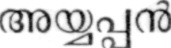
അയ്യപ്പന്‍
